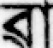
ৱা
